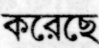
করেছে
